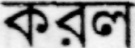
করল
